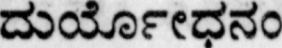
ದುರ್ಯೋಧನಂ
